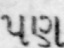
પણ
